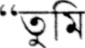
“তুমি
